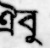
ঐবু
